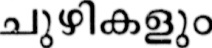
ചുഴികളും
